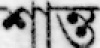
শান্ত
